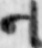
ન
